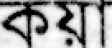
কয়া
